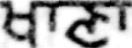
ਖਾਣਾ
